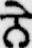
ਨੇ
